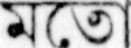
মতো
